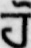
ਹੋ
